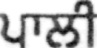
ਪਾਲੀ
